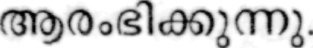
ആരംഭിക്കുന്നു.
